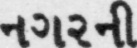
નગરની
